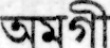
অমগী
